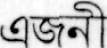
এজনী
